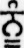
ਨੂੰ
